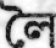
লৈ
